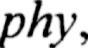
phy,
